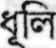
ধূলি
